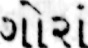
ગોરાં
